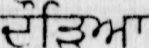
ਦੌੜਿਆ
